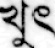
খুৎ
